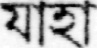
যাহা
